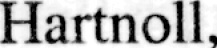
Hartnoll,
